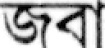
জবা
